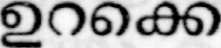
ഉറക്കെ
